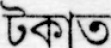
টকাত
